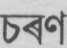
চৰণ
